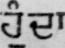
ਹੁੰਦਾ
